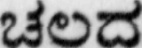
ಚಲದ
